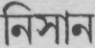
নিসান
